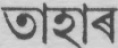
তাহাৰ
